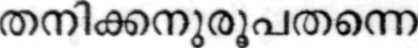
തനിക്കനുരൂപതന്നെ
